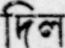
দিল
